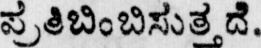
ಪ್ರತಿಬಿಂಬಿಸುತ್ತದೆ.
